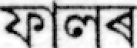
ফালৰ
